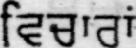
ਵਿਚਾਰਾਂ
